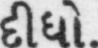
દીધો.
